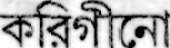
করিগীনো
